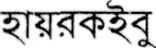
হায়রকইবু
